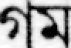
গম
